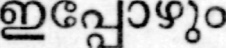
ഇപ്പോഴും
